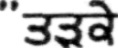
''ਤੜਕੇ
